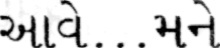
આવે...મને
